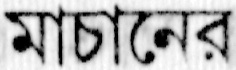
মাচানের
